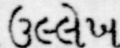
ઉલ્લેખ
